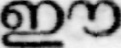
ഈ
